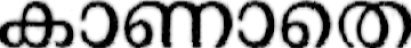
കാണാതെ
